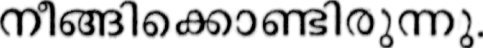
നീങ്ങിക്കൊണ്ടിരുന്നു.
